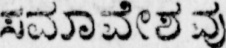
ಸಮಾವೇಶವು
